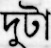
দুটা
